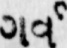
ગર્વ
